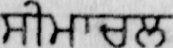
ਸੀਮਾਚਲ
